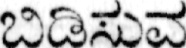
ಬಿಡಿಸುವ
